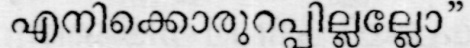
എനിക്കൊരുറപ്പില്ലല്ലോ”
